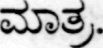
ಮಾತ್ರ.
